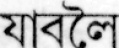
যাবলৈ
